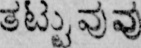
ತಟ್ಟುವುವು
